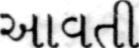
આવતી
